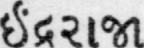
ઇંદ્રરાજા
